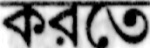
করতে
